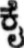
ಕೈ
